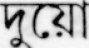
দুয়ো
